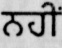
ਨਹੀਂ
